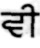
ਵੀ
